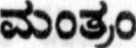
ಮಂತ್ರ೦
